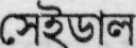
সেইডাল
